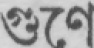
গুণে
